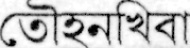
তৌহনখিবা
